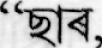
"ছাৰ,
